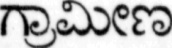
ಗ್ರಾಮೀಣ
